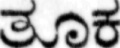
ತೂಕ
